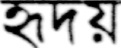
হৃদয়
